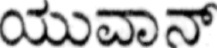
ಯುವಾನ್
